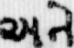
અને
